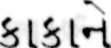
કાકાને
